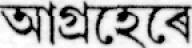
আগ্ৰহেৰে
